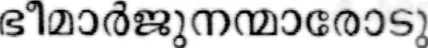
ഭീമാര്‍ജുനന്മാരോടു
